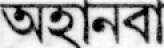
অহানবা
